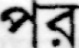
পর
